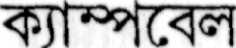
ক্যাম্পবেল
